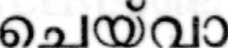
ചെയ്വാ
